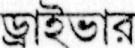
ড্রাইভার
